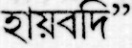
হায়বদি”
